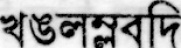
খঙলম্লবদি
